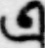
এ
